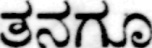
ತನಗೂ
